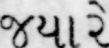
જ્યારે
